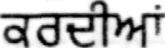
ਕਰਦੀਆਂ
